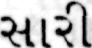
સારી
